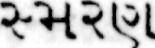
સ્મરણ
